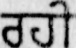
ਰਹੀ
